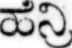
ಹೆನ್ರಿ
